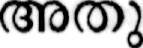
അതു
